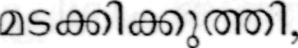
മടക്കിക്കുത്തി,
